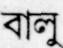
বালু
